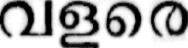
വളരെ
